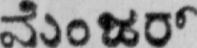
ಮೆಂಜರ್
